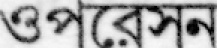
ওপরেসন
